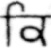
ਕਿ
